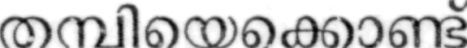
തമ്പിയെക്കൊണ്ട്
